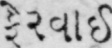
ફેરવાઈ
